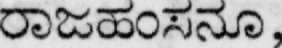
ರಾಜಹಂಸನೂ,
